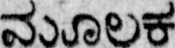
ಮೂಲಕ
